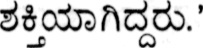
ಶಕ್ತಿಯಾಗಿದ್ದರು.'
